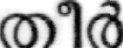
തീര്‍
